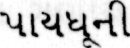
પાયધૂની
